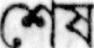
শেষ
